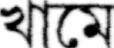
খামে
